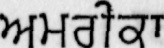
ਅਮਰੀਕਾ
